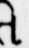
તે
